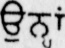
ਉਨ੍ਹਾਂ
